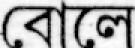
বোলে
